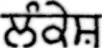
ਲੰਕੇਸ਼
